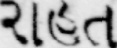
રાહત
